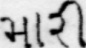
મારી
